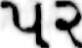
પર
